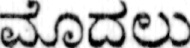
ಮೊದಲು
